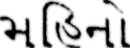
મહિનો
